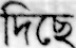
দিছে
